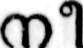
നീ
